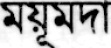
ময়ূমদা
